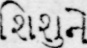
શિશુને
